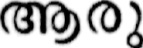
ആരു
